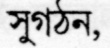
সুগঠন,
